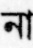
না
